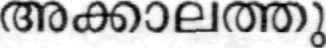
അക്കാലത്തു
